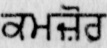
ਕਮਜ਼ੋਰ
